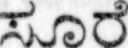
ಸೂರೆ
